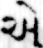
એ
